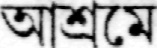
আশ্রমে
